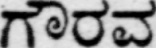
ಗೌರವ
